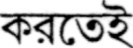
করতেই
